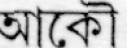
আকৌ
